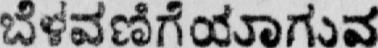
ಬೆಳವಣಿಗೆಯಾಗುವ
